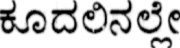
ಕೂದಲಿನಲ್ಲೇ
